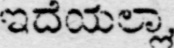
ಇದೆಯಲ್ಲಾ,
